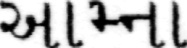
આમ્ના
